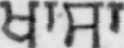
ਖਾਸਾ
